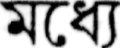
মধ্যে
